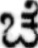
ಚೆ
